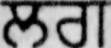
ਲਗ
